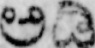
ಅಡಿ
